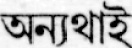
অন্যথাই
